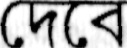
দেবে
